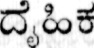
ದೈಹಿಕ
